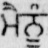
ਮੈਨੂੰ
